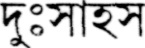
দুঃসাহস
